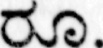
ರೂ.
